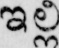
ಇಲ್ಲಿ
